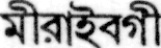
মীরাইবগী
